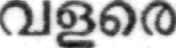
വളരെ
